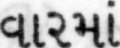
વારમાં
